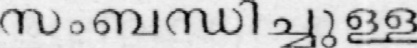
സംബന്ധിച്ചുള്ള
